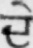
ਦੇ
